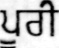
ਪੂਰੀ
